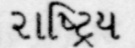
રાષ્ટ્રિય
